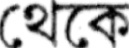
থেকে
